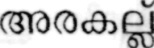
അരകല്ല്
